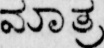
ಮಾತ್ರ
